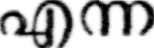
എന്ന
